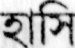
হাসি
